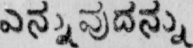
ಎನ್ನುವುದನ್ನು
